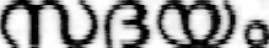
സദയം
